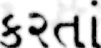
કરતાં
